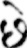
છે
